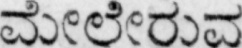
ಮೇಲೇರುವ
